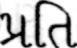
પ્રતિ
